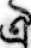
ঐ
